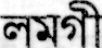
লমগী
